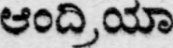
ಆಂದ್ರಿಯಾ
